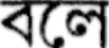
বলে
